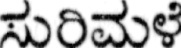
ಸುರಿಮಳೆ
